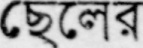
ছেলের
